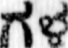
ಗಳ
